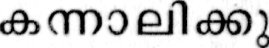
കന്നാലിക്കു
